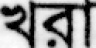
খরা
